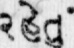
રહેતું
